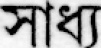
সাধ্য
